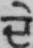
ਦੇ
